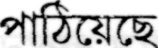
পাঠিয়েছে
